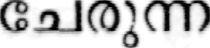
ചേരുന്ന
